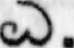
ಎ.
